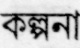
কল্পনা
